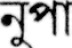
নুপা
